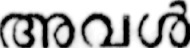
അവള്‍
